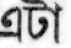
এটা
